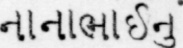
નાનાભાઈનું
